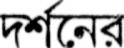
দর্শনের
